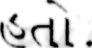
હતો.
